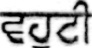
ਵਹੁਟੀ
